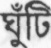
ঘুঁটি
